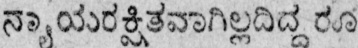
ನ್ಯಾಯರಕ್ಷಿತವಾಗಿಲ್ಲದಿದ್ದರೂ
